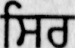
ਸਿਰ
